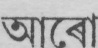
আৰো
